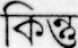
কিন্তু
